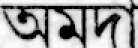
অমদা
